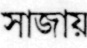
সাজায়
